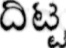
ದಿಟ್ಟ
